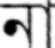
না
